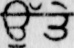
ਉੱਤੇ
